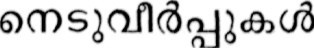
നെടുവീര്‍പ്പുകള്‍
